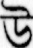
উ
